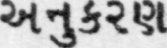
અનુકરણ
